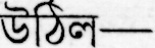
উঠিল-
